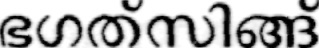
ഭഗത്സിങ്ങ്
